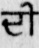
ਦੀ
